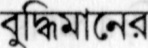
বুদ্ধিমানের
